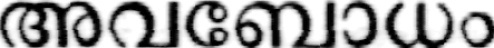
അവബോധം
